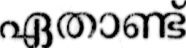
ഏതാണ്ട്
